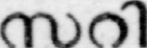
സറി
